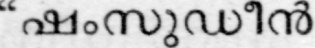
"ഷംസുഡീന്‍
